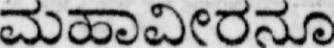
ಮಹಾವೀರನೂ
